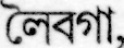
লৈবগা,
